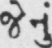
જેનું
